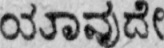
ಯಾವುದೇ
